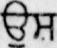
ਉਸ
